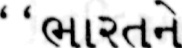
"ભારતને
